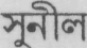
সুনীল
